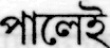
পালেই
